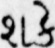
શકે
